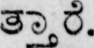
ತ್ತಾರೆ.
